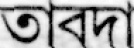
তাবদা
